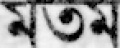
মতম
